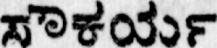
ಸೌಕರ್ಯ
